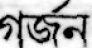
গর্জন
